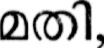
മതി,
